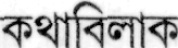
কথাবিলাক
